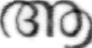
ആ
